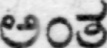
ಅಂತ
